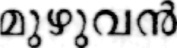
മുഴുവന്‍
